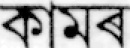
কামৰ
